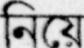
নিয়ে
